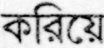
করিয়ে
